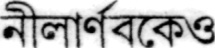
নীলার্ণবকেও
